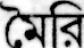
মৈরি
